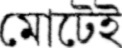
মোটেই
